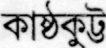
কাষ্ঠকুট্ট
